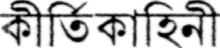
কীর্তিকাহিনী
